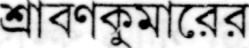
শ্রাবণকুমারের
